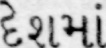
દેશમાં
